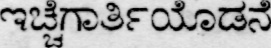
ಇಚ್ಚೆಗಾರ್ತಿಯೊಡನೆ
